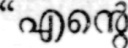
“എന്റെ
